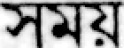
সময়
